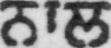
ਨਾਲ
